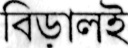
বিড়ালই
